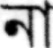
না
